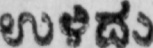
ಉಳಿದು
